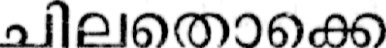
ചിലതൊക്കെ
